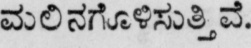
ಮಲಿನಗೊಳಿಸುತ್ತಿವೆ.
